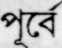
পূর্বে
